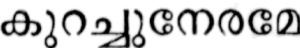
കുറച്ചുനേരമേ
